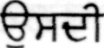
ਉਸਦੀ
